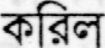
করিল
